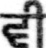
ਵੀ
